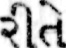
રીતે
